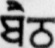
ਬੈਠ
